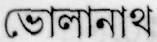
ভোলানাথ
